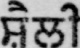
ਸ਼ੈਲੀ
